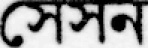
সেসন
